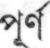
পূৰ্ণ
